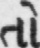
તો
